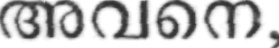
അവനെ,
